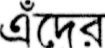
এঁদের
